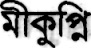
মীকুপ্নি
